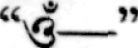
"ওঁ-"
